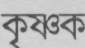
কৃষ্ণক
